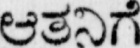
ಆತನಿಗೆ
